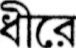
ধীরে
